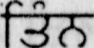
ਤਿੰਨ
